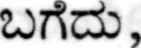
ಬಗೆದು,
